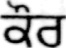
ਕੌਰ
